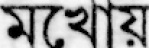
মখোয়
